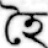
হৈ
